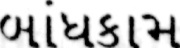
બાંધકામ
